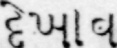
દેખાવ
